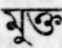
মুক্ত
